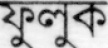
ফুলুক
